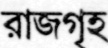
রাজগৃহ
